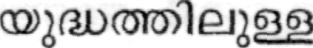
യുദ്ധത്തിലുള്ള
